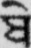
ਬੇ
